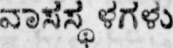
ವಾಸಸ್ಥಳಗಳು
